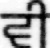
ਵੀ
